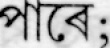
পাৰে;
